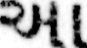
આ
